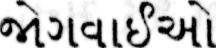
જોગવાઈઓ
